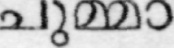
ചുമ്മാ
